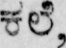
ಕಲೆ,
